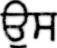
ਉਸ
